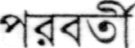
পরবর্তী
